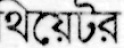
থিয়েটর
